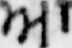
ਆ
